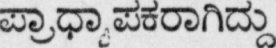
ಪ್ರಾಧ್ಯಾಪಕರಾಗಿದ್ದು
